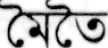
মৈতৈ
